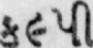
કલ્પી
